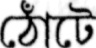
ঠোঁটে
